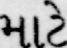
માટે
